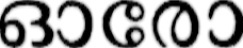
ഓരോ
